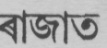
ৰাজাত
